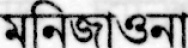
মনিজাওনা
